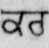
ਕਰ
